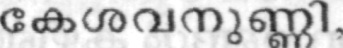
കേശവനുണ്ണി,
